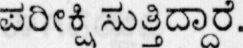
ಪರೀಕ್ಷಿಸುತ್ತಿದ್ದಾರೆ.
